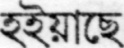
হইয়াছে
